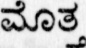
ಮೊತ್ತ
